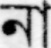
না
